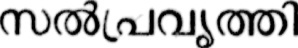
സല്‍പ്രവൃത്തി
